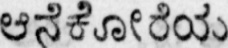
ಆನೆಕೋರೆಯ
